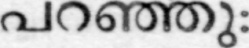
പറഞ്ഞു:
